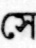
সে
